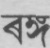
ৰঙ্গ
